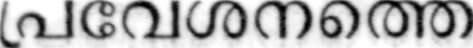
പ്രവേശനത്തെ
